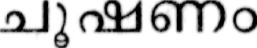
ചൂഷണം
